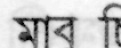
থম্বৌনা
